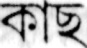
কাছ
